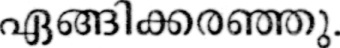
ഏങ്ങിക്കരഞ്ഞു.
